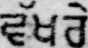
ਵੱਖਰੇ
